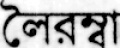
লৈরম্বা
